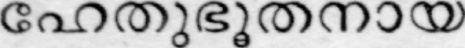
ഹേതുഭൂതനായ
